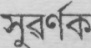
সুৱৰ্ণক
